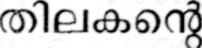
തിലകന്റെ
